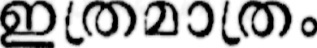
ഇത്രമാത്രം
